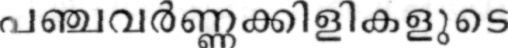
പഞ്ചവര്‍ണ്ണക്കിളികളുടെ
